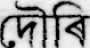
দৌৰি
